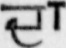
ਦਾ
